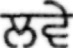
ਲਵੇ
